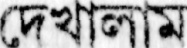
দেখালাম
